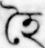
হৈ
